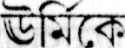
ঊর্মিকে
